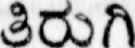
ತಿರುಗಿ
